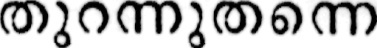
തുറന്നുതന്നെ
